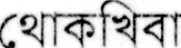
থোকখিবা
